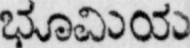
ಭೂಮಿಯ
